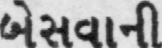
બેસવાની
